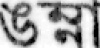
ঙম্না
